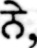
ਨੇ,
